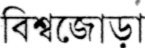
বিশ্বজোড়া
